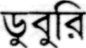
ডুবুরি
